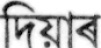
দিয়াৰ
